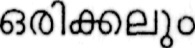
ഒരിക്കലും
